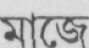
মাজে
